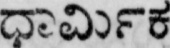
ಧಾರ್ಮಿಕ
